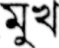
মুখ
